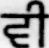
ਵੀ
